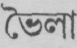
ভৈলা
